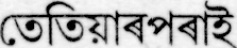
তেতিয়াৰপৰাই
